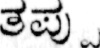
ತಪ್ಪು
